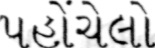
પહોંચેલો
